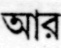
আর
